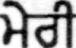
ਮੇਰੀ
